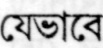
যেভাবে
